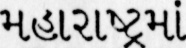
મહારાષ્ટ્રમાં
